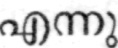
എന്നു
